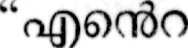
“എന്റെ
